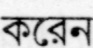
করেন
